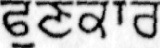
ਫੁਣਕਾਰ
